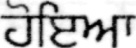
ਹੋਇਆ
